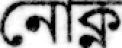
নোক্ন
